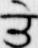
ਤੇ
